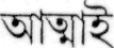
আত্মাই
